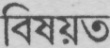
বিষয়ত
